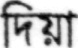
দিয়া
